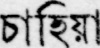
চাহিয়া
